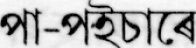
পা-পইচাৰে
